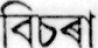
বিচৰা
